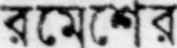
রমেশের
